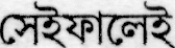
সেইফালেই
